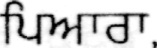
ਪਿਆਰਾ,
